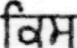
ਕਿਸ
